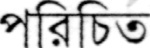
পরিচিত
